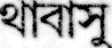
থাবাসু
